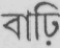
বাঢ়ি
